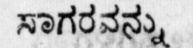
ಸಾಗರವನ್ನು
